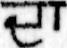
ਦਾ
